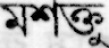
মশক্তু
